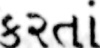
કરતાં
